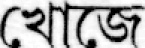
খোজে
